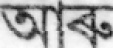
আৰু
